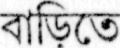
বাড়িতে
